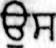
ਉਸ
